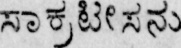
ಸಾಕ್ರಟೀಸನು
